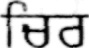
ਚਿਰ
